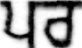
ਪਰ
